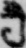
ਹੈ
